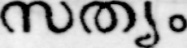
സത്യം
